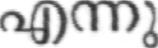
എന്നു
